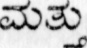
ಮತ್ತು
